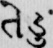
તેડું
